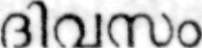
ദിവസം
